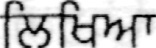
ਲਿਖਿਆ
